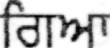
ਗਿਆ
